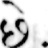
છે.
